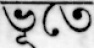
ভূতে
